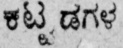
ಕಟ್ಟಡಗಳ
